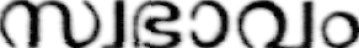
സ്വഭാവം
